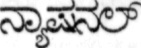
ನ್ಯಾಷನಲ್
